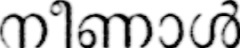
നീണാള്‍
